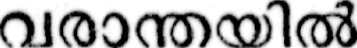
വരാന്തയില്‍
